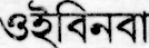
ওইবিনবা
